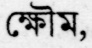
ক্ষৌম,
